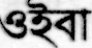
ওইবা
